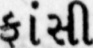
ફાંસી
